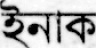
ইনাক
